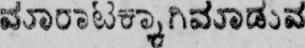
ಮಾರಾಟಕ್ಕಾಗಿಮಾಡುವ
